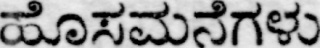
ಹೊಸಮನೆಗಳು
